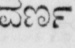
ವರ್ಣ
